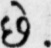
છે.
